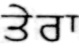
ਤੇਰਾ
